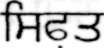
ਸਿਫ਼ਤ
